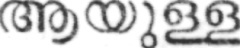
ആയുള്ള
